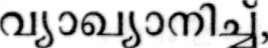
വ്യാഖ്യാനിച്ച്,
